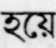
হয়ে
